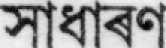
সাধাৰণ
